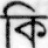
কি
